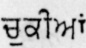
ਚੁਕੀਆਂ
